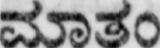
ಮಾತಂ
